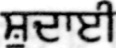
ਸ਼ੁਦਾਈ
